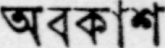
অবকাশ
